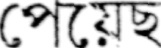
পেয়েছ
